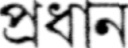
প্রধান
